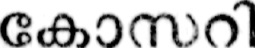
കോസറി
